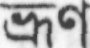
ভ্রূণ
